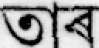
তাৰ
